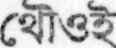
থৌওই
